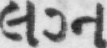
લગ્ન
